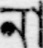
না
